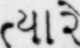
ત્યારે
